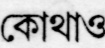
কোথাও
